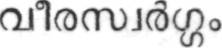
വീരസ്വര്‍ഗ്ഗം
